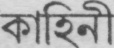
কাহিনী
